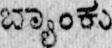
ಬ್ಯಾಂಕು
